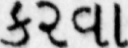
કરવા
